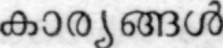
കാര്യങ്ങള്‍
